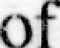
of
